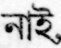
নাই,
